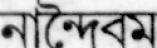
নান্দৈবম
